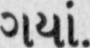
ગયાં.
